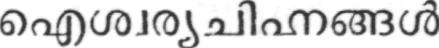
ഐശ്വര്യചിഹ്നങ്ങള്‍
